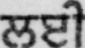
ਲਈ
